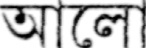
আলো
